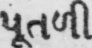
પૂતળી
